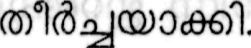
തീര്‍ച്ചയാക്കി.
